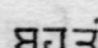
ਬਹਤੀ
